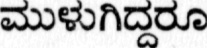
ಮುಳುಗಿದ್ದರೂ
